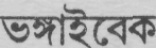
ভঙ্গাইবেক
